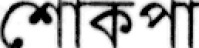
শোকপা
